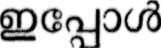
ഇപ്പോള്‍
